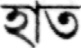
হাত
